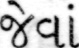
જેવાં
